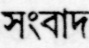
সংবাদ
